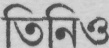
তিনিও
